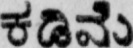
ಕಡಿಮೆ
